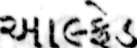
આલ્ફ્રેડ
